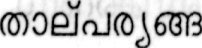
താല്പര്യങ്ങ
